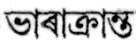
ভাৰাক্রান্ত
